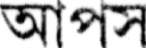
আপস
